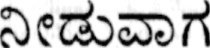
ನೀಡುವಾಗ
